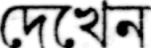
দেখেন
